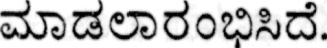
ಮಾಡಲಾರಂಭಿಸಿದೆ.
